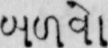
બળવો
